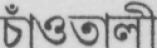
চাঁওতালী
